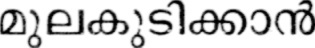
മുലകുടിക്കാന്‍
